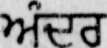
ਅੰਦਰ
